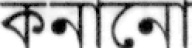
কনানো
